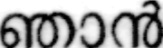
ഞാന്‍
